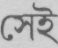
সেই
